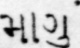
માગું
